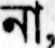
না,
